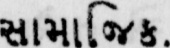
સામાજિક.
